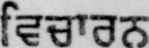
ਵਿਚਾਰਨ
